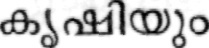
കൃഷിയും
